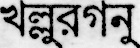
খল্লুরগনু
